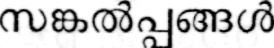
സങ്കല്‍പ്പങ്ങള്‍
